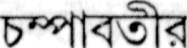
চম্পাবতীর
